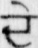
ਦੇ
